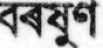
বৰষুণ
